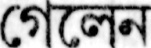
গেলেন
